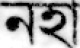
নহা
